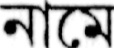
নামে
